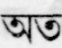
অত
